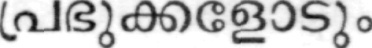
പ്രഭുക്കളോടും
